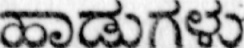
ಹಾಡುಗಳು
